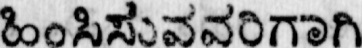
ಹಿಂಸಿಸುವವರಿಗಾಗಿ
